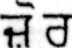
ਜ਼ੋਰ
